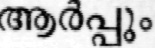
ആര്‍പ്പും
